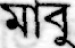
মাবু
